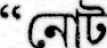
“নোট
